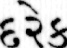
દરેક
